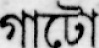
গাটো
